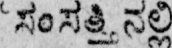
‘ಸಂಸತ್ತಿನಲ್ಲಿ
